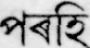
পৰহি
